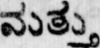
ಮತ್ತು
